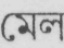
মেল
